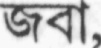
জবা,
